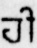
ਹੀ
